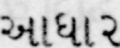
આધાર
